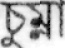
চুম্না
